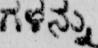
ಗಳನ್ನು
